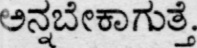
ಅನ್ನಬೇಕಾಗುತ್ತೆ.
